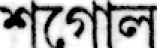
শগোল
